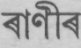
ৰাণীৰ
